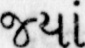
જ્યાં
